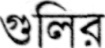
গুলির
